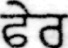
ਫੇਰ
